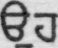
ਉਹ
